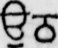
ਉਠ
